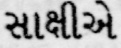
સાક્ષીએ
